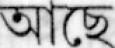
আছে
